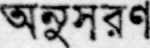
অনুসরণ
